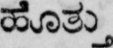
ಹೊತ್ತು
